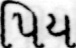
પિય
